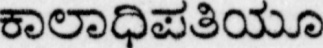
ಕಾಲಾಧಿಪತಿಯೂ
